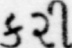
કરી
